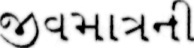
જીવમાત્રની
